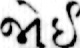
જોઈ
